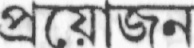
প্রয়োজন
